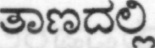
ತಾಣದಲ್ಲಿ
